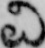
ವಿ
